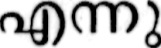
എന്നു
